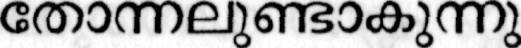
തോന്നലുണ്ടാകുന്നു
